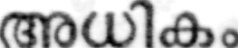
അധികം
